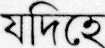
যদিহে
